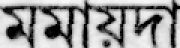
মমায়দা
